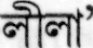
লীলা'
